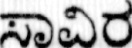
ಸಾವಿರ
